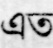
এত
